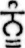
ਨੂੰ
